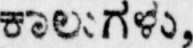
ಕಾಲುಗಳು,
